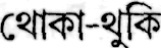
থোকা-থুকি
